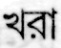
খরা
